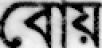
বোয়
